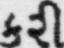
કરી
